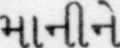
માનીને
